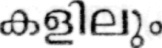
കളിലും
